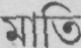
মাতি
